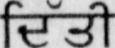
ਦਿੱਤੀ
